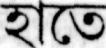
হাতে
